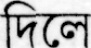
দিলে
